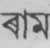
ৰাম
